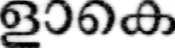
ളാകെ
